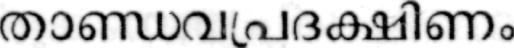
താണ്ഡവപ്രദക്ഷിണം
